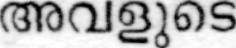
അവളുടെ
